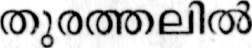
തുരത്തലില്‍
